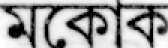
মকোক
